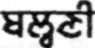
ਬਲ੍ਹਣੀ
